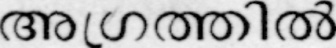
അഗ്രത്തില്‍
